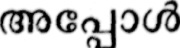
അപ്പോള്‍
